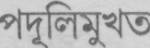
পদূলিমুখত
